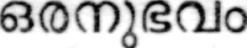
ഒരനുഭവം
